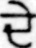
ਦੇ
